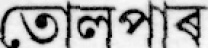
তোলপাৰ
